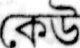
কেউ
